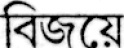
বিজয়ে
